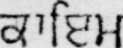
ਕਾਇਮ
